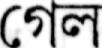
গেল
